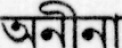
অনীনা
